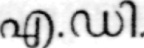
എ.ഡി.
